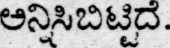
ಅನ್ನಿಸಿಬಿಟ್ಟಿದೆ.
